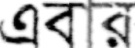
এবার
